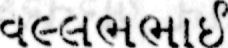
વલ્લભભાઈ
